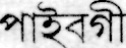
পাইবগী
